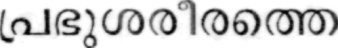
പ്രഭുശരീരത്തെ
